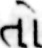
તો
